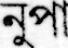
নুপা
